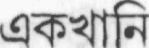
একখানি
